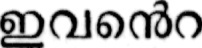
ഇവന്റെ
